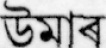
উমাৰ
